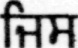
ਜਿਸ
